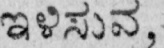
ಇಳಿಸುವ,
